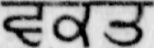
ਵਕਤ
